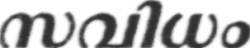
സവിധം
